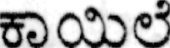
ಕಾಯಿಲೆ
